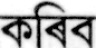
কৰিব
